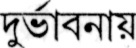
দুর্ভাবনায়
